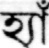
হ্যাঁ
